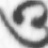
ও
